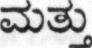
ಮತ್ತು
